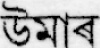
উমাৰ
